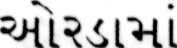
ઓરડામાં
